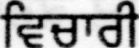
ਵਿਚਾਰੀ
